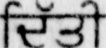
ਦਿੱਤੀ
